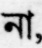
না,
